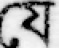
যে
